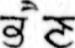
ਭੈਣ
